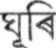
ঘূৰি
